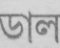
ডাল
